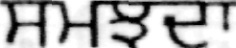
ਸਮਝਦਾ
